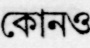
কোনও
